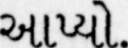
આપ્યો.
